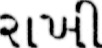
રાખી
